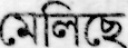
মেলিছে
